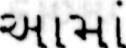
આમાં
